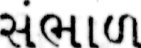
સંભાળ
